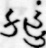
કહું
